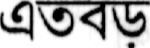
এতবড়
